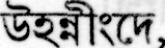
উহন্নীংদে,
